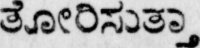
ತೋರಿಸುತ್ತಾ
